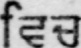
ਵਿਚ
